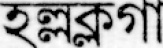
হল্লক্লগা
